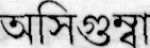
অসিগুম্বা
